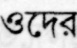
ওদের
